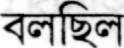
বলছিল
